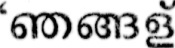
‘ഞങ്ങള്
